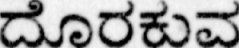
ದೊರಕುವ
